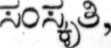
ಸಂಸ್ಕೃತಿ,
